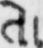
તો
